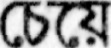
চেয়ে
